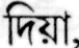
দিয়া,
